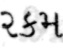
રકમ
